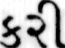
કરી
